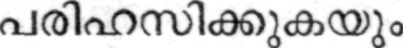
പരിഹസിക്കുകയും
